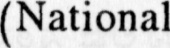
(National
